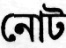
নোট
